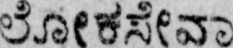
ಲೋಕಸೇವಾ
